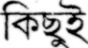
কিছুই
